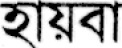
হায়বা
